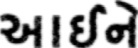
આઈને
